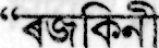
"ৰজকিনী
